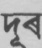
দূৰ
